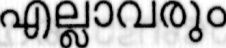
എല്ലാവരും
